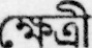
ক্ষেত্রী
